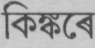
কিঙ্কৰে
